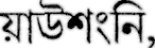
য়াউশংনি,
